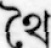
থৈ
